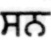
ਸਨ
